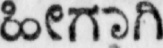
ಹೀಗಾಗಿ
